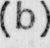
(b)
